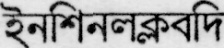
ইনশিনলক্লবদি
